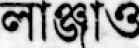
লাঞ্জাও
